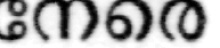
നേരെ
